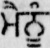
ਮੈਨੂੰ
